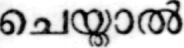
ചെയ്താല്‍
